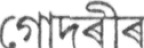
গোদৰীৰ
